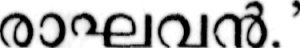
രാഘവന്‍.’
